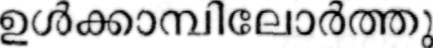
ഉള്‍ക്കാമ്പിലോര്‍ത്തു
